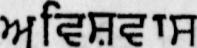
ਅਵਿਸ਼ਵਾਸ
